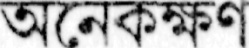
অনেকক্ষণ
